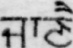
ਜਾਣੈ
